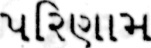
પરિણામ
